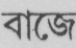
বাজে
